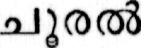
ചൂരല്‍
